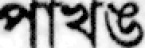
পাখঙ
